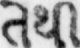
તેથી
